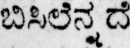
ಬಿಸಿಲೆನ್ನದೆ
